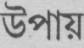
উপায়
